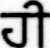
ਹੀ
